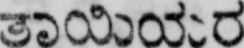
ತಾಯಿಯರ
